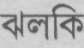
ঝলকি
